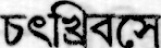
চৎখ্রিবসে
